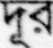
দূর
